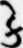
કે
